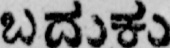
ಬದುಕು
